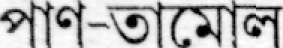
পাণ-তামোল
